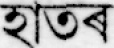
হাতৰ
